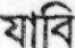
যাবি
